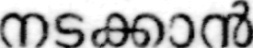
നടക്കാന്‍
